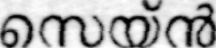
സെയ്ന്‍
